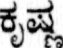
ಕೃಷ್ಣ
